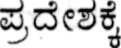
ಪ್ರದೇಶಕ್ಕೆ
